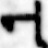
ન
